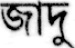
জাদু
